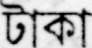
টাকা
